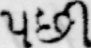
પછી
